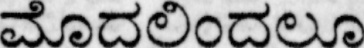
ಮೊದಲಿಂದಲೂ
